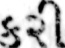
કરી
